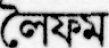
লৈফম
